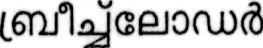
ബ്രീച്ച്ലോഡര്‍
